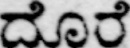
ದೊರೆ
